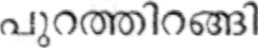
പുറത്തിറങ്ങി
